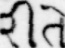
રીતે
